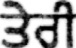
ਤੇਰੀ
